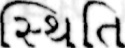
સ્થિતિ
